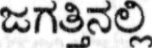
ಜಗತ್ತಿನಲ್ಲಿ
